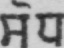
ਸੋਧ
